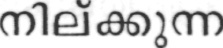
നില്ക്കുന്ന
